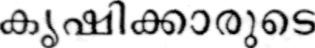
കൃഷിക്കാരുടെ
